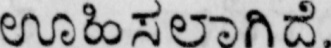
ಊಹಿಸಲಾಗಿದೆ.
